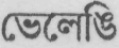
ভেলেঙি
